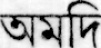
অমদি
